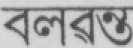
বলৱন্ত
